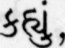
કહ્યું,
